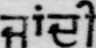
ਜਾਂਦੀ
